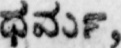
ಧರ್ಮ,
